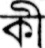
কী
